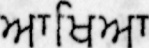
ਆਖਿਆ
